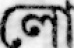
লো
